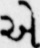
એ
